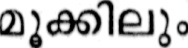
മൂക്കിലും
